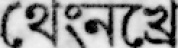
থেংনখ্রে
